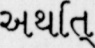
અર્થાત્
